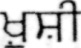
ਖ਼ੁਸ਼ੀ
